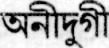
অনীদুগী
